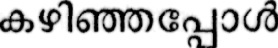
കഴിഞ്ഞപ്പോള്‍
